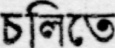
চলিতে
